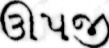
ઊપજી
